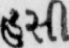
હસી
